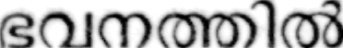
ഭവനത്തില്‍
